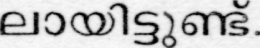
ലായിട്ടുണ്ട്.
